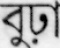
বুঢ়া
